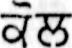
ਕੋਲ
